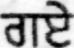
ਗਏ
